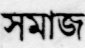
সমাজ
